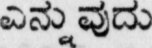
ಎನ್ನುವುದು
